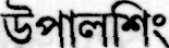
উপালশিং
